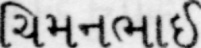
ચિમનભાઈ
